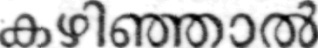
കഴിഞ്ഞാല്‍
